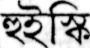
হুইস্কি
